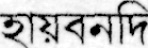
হায়বনদি
